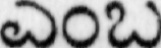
ಎಂಬ
